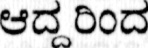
ಆದ್ದರಿಂದ
